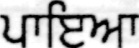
ਪਾਇਆ
